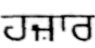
ਹਜ਼ਾਰ
